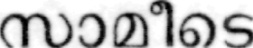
സാമീടെ
